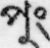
পুং
